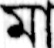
মা
